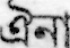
ঐনা
